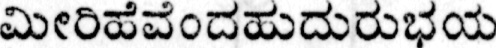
ಮೀರಿಹೆವೆಂದಹುದುರುಭಯ
